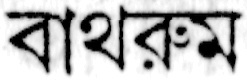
বাথরুম
